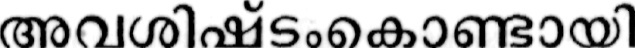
അവശിഷ്ടംകൊണ്ടായി
